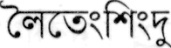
লৈতেংশিংদু
